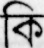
কি
